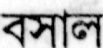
বসাল
